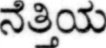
ನೆತ್ತಿಯ
